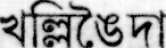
খল্লিঙৈদা
